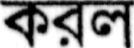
করল
